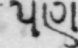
પણ
